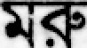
মরু
